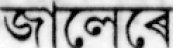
জালেৰে
